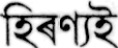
হিৰণ্যই
